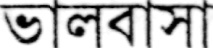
ভালবাসা
